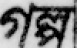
গল্প
